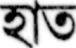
হাত
